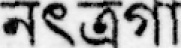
নৎত্রগা
